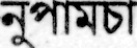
নুপামচা
